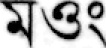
মওং
